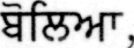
ਬੋਲਿਆ,
